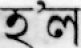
হ'ল
